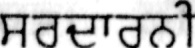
ਸਰਦਾਰਨੀ
